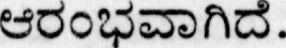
ಆರಂಭವಾಗಿದೆ.
